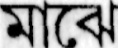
মাঝে
